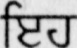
ਇਹ
